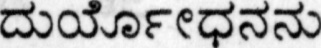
ದುರ್ಯೋಧನನು
